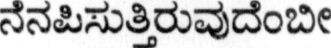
ನೆನಪಿಸುತ್ತಿರುವುದೆಂಬೀ
